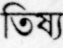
তিষ্য
